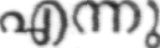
എന്നു
